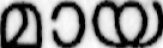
മായ
